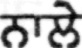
ਨਾਲੇ
